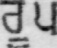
ਰੂਪ
